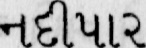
નદીપાર
